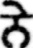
ਨੇ
